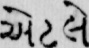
એટલે
